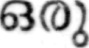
ഒരു
